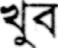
খুব
